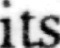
its
